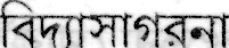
বিদ্যাসাগরনা
